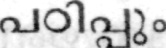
പഠിപ്പും
